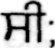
ਸੀ;
